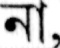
না,
